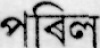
পৰিল
